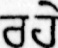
ਰਹੇ
